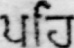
ਪਹਿ
